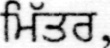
ਮਿੱਤਰ,
